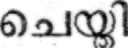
ചെയ്തി
